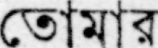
তোমার
